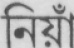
নিয়াঁ
